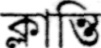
ক্লান্তি
